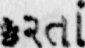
કરતાં
